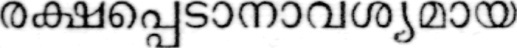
രക്ഷപ്പെടാനാവശ്യമായ
